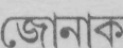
জোনাক
